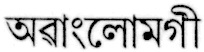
অৱাংলোমগী
